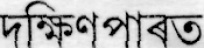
দক্ষিণপাৰত
